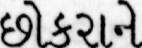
છોકરાને
